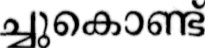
ച്ചുകൊണ്ട്
